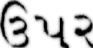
ઉપર
